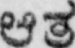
ಆತ
